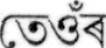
তেওঁৰ
